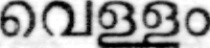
വെള്ളം
